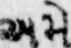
અમે
